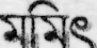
মমিৎ
